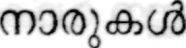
നാരുകള്‍
